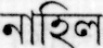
নাহিল
